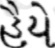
હૈયે
